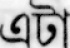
এটা
